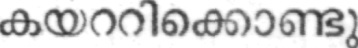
കയററിക്കൊണ്ടു
